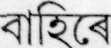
বাহিৰে
